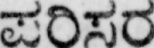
ಪರಿಸರ
